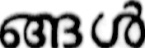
ങ്ങള്‍
